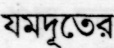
যমদূতের
